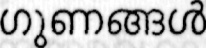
ഗുണങ്ങള്‍
